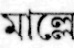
মাল্লে
